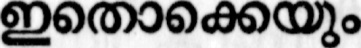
ഇതൊക്കെയും
